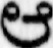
ಆ
